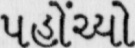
પહોંચ્યો
